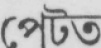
পেটত
